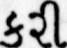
કરી
